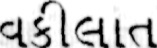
વકીલાત
